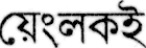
য়েংলকই
